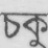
চকু
